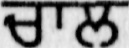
ਚਾਲ
